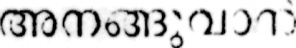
അനങ്ങുവാന്‍
